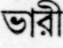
ভারী
